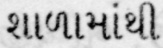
શાળામાંથી
